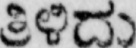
ತಿಳಿದು
